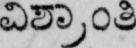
ವಿಶ್ರಾಂತಿ
